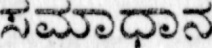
ಸಮಾಧಾನ
